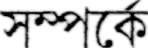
সম্পর্কে
